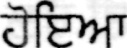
ਹੋਇਆ
